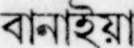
বানাইয়া
